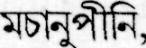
মচানুপীনি,
